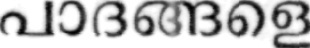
പാദങ്ങളെ
